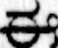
ಈ
